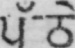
ਪੱਠੇ
